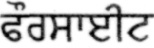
ਫੌਰਸਾਈਟ
